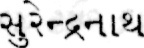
સુરેન્દ્રનાથ
